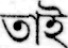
তাই
